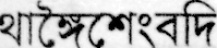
থাঙ্গৈশেংবদি
